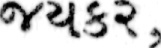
જયકર,
